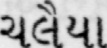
ચલૈયા
